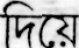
দিয়ে
